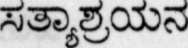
ಸತ್ಯಾಶ್ರಯನ
